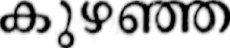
കുഴഞ്ഞ
